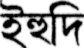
ইহুদ
